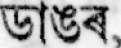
ডাঙৰ,
